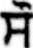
ਸੌ
